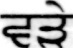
ਵੜੇ
